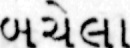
બચેલા
